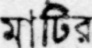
মাটির
